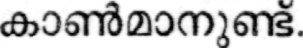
കാണ്‍മാനുണ്ട്.
